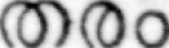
തരം
